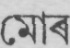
মোৰ
